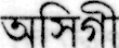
অসিগী
